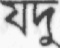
যদু
